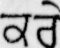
ਕਰੇ
